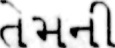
તેમની
